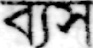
ব্যস
